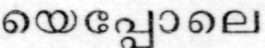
യെപ്പോലെ
